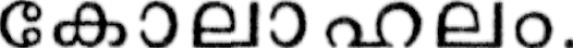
കോലാഹലം.
